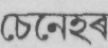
চেনেহৰ
